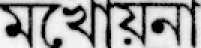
মখোয়না
